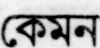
কেমন
